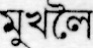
মুখলৈ
